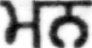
ਮਨ
